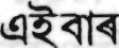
এইবাৰ
